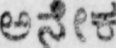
ಅನೇಕ
